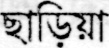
ছাড়িয়া
